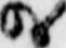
જ
